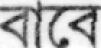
বাবে
